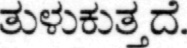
ತುಳುಕುತ್ತದೆ.
